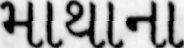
માથાના
